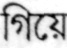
গিয়ে
